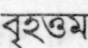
বৃহত্তম
